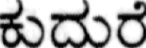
ಕುದುರೆ
